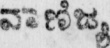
ವಾಣಿಜ್ಯ
